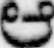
ಆ
